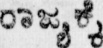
ರಾಜ್ಯಕ್ಕೆ
